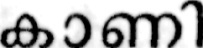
കാണി
